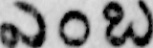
ಎಂಬ
